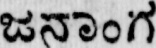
ಜನಾಂಗ
